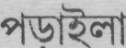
পড়াইলা
